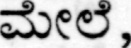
ಮೇಲೆ,
